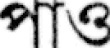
পাও
